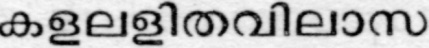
കളലളിതവിലാസ
